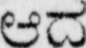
ಆದ
